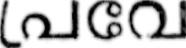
പ്രവേ
